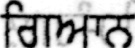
ਗਿਆਨ
